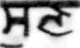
ਸੁਣ
